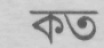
কত
